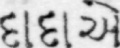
દાદાએ
